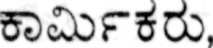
ಕಾರ್ಮಿಕರು,
